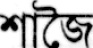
শাজৈ
